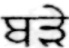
ਬੜੇ
